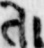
તો
